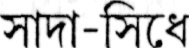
সাদা-সিধে
